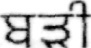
ਬੜੀ
